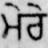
ਮੇਰੇ
